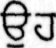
ਉਹ
